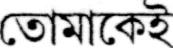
তোমাকেই
